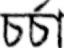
চর্চা
